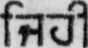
ਜਿਹੀ
